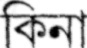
কিনা
